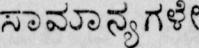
ಸಾಮಾನ್ಯಗಳೇ
